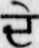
ਦੇ
